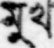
মুখ
